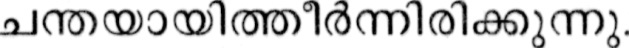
ചന്തയായിത്തീര്‍ന്നിരിക്കുന്നു.
